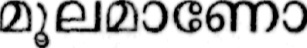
മൂലമാണോ
